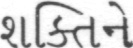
શક્તિને
